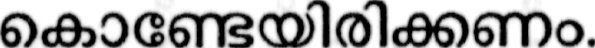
കൊണ്ടേയിരിക്കണം.
